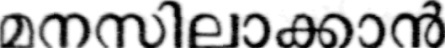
മനസിലാക്കാന്‍
